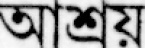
আশ্রয়
